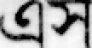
এস
